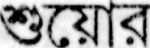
শুয়োর
